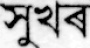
সুখৰ
